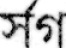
র্সগ
